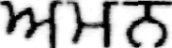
ਅਮਨ
